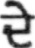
ਦੇ
